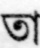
তা
